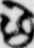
છે
